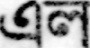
এল
